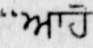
''ਆਹੋ
